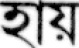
হায়
